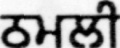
ਠਮਲੀ
